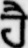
ਹੈ
